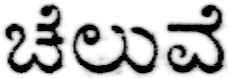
ಚೆಲುವೆ
